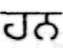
ਹਨ
